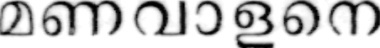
മണവാളനെ
